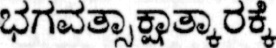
ಭಗವತ್ಸಾಕ್ಷಾತ್ಕಾರಕ್ಕೆ
